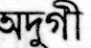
অদুবু
